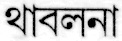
থাবলনা
